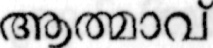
ആത്മാവ്
